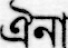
ঐনা
